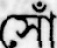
সোঁ
